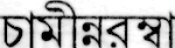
চামীন্নরম্বা
